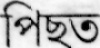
পিছত
